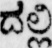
ದಲ್ಲಿ
